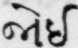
જોઈ
